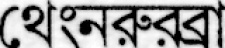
থেংনরুরব্রা
